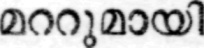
മററുമായി
